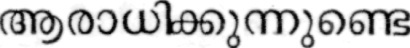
ആരാധിക്കുന്നുണ്ടെ
